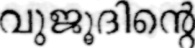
വുജൂദിന്റെ
